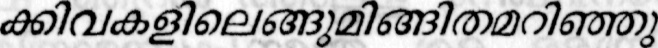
ക്കിവകളിലെങ്ങുമിങ്ങിതമറിഞ്ഞു
